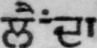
ਲੈਂਦਾ
